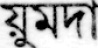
য়ুমদা
